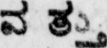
ಮತ್ತು
